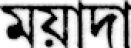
ময়াদা
